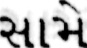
સામે
